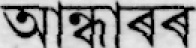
আন্ধাৰৰ
